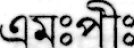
এমঃপীঃ
